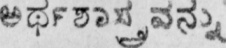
ಅರ್ಥಶಾಸ್ತ್ರವನ್ನು
